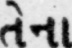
તેના
